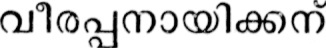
വീരപ്പനായിക്കന്
